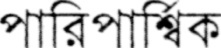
পারিপার্শ্বিক
